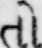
તો
